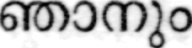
ഞാനും
